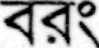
বরং
